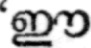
‘ഈ
